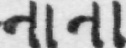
નાના
